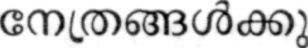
നേത്രങ്ങള്‍ക്കു
